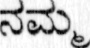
ನಮ್ಮ
